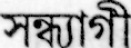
সন্ধ্যাগী
